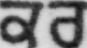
ਕਰ
